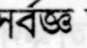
সর্বজ্ঞ
